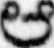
ಆ
